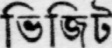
ভিজিট
